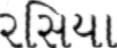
રસિયા
